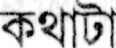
কথাটা
